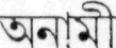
অনামী
